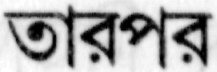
তারপর
